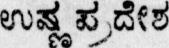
ಉಷ್ಣಪ್ರದೇಶ
